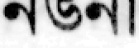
নঙনা
